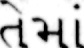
તેમાં
